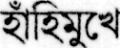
হাঁহিমুখে
